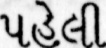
પહેલી
